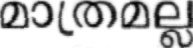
മാത്രമല്ല
